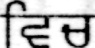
ਵਿਚ
